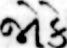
જોકે
